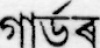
গার্ডৰ
